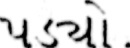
પડ્યો.
